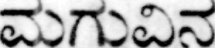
ಮಗುವಿನ
